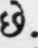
છે.
